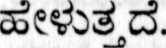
ಹೇಳುತ್ತದೆ.
